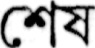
শেষ
